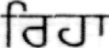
ਰਿਹਾ
